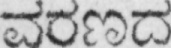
ವರಣದ
